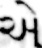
એ
